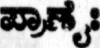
ಪ್ರಾಣೈಃ
